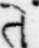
તેં
